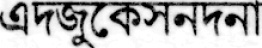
এদজুকেসনদনা
